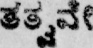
ತತ್ವವೇ
